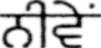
ਨੀਵੇਂ
